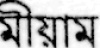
মীয়াম
